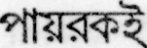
পায়রকই
